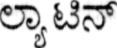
ಲ್ಯಾಟಿನ್
